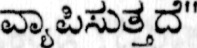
ವ್ಯಾಪಿಸುತ್ತದೆ”
